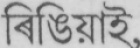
ৰিঙিয়াই,
